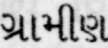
ગ્રામીણ
